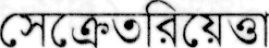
সেক্রেতরিয়েত্তা
